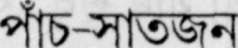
পাঁচ-সাতজন
